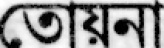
তোয়না
